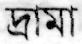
দ্রামা
